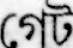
গেট
